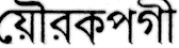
য়ৌরকপগী
